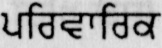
ਪਰਿਵਾਰਿਕ
